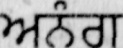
ਅਨੰਗ
